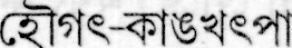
হৌগৎ-কাঙখৎপা
